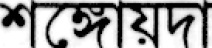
শঙ্গোয়দা
